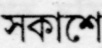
সকাশে
